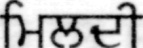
ਮਿਲਦੀ
